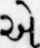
એ
